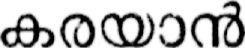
കരയാന്‍
